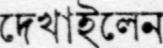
দেখাইলেন
